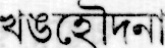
খঙহৌদনা
